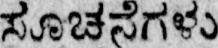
ಸೂಚನೆಗಳು
